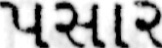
પસાર
